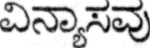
ವಿನ್ಯಾಸವು
